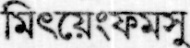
মিৎয়েংফমসু
